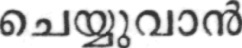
ചെയ്യുവാന്‍
